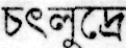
চৎলুদ্রে
